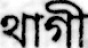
থাগী
